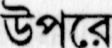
উপরে
